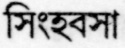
সিংহবসা
